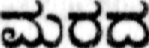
ಮರದ
